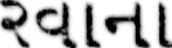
રવાના
